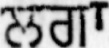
ਲਗਾ
